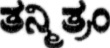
ತನ್ಮಿತ್ರಂ
